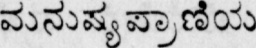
ಮನುಷ್ಯಪ್ರಾಣಿಯ
